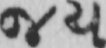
જય
